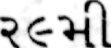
૨૯મી
